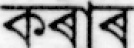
কৰাৰ
